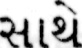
સાથે
